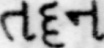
તદૃન
